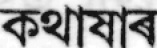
কথাষাৰ
